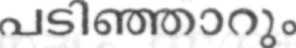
പടിഞ്ഞാറും
